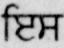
ਇਸ
